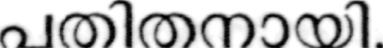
പതിതനായി.
